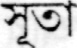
সূতা
